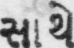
સાથે
